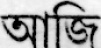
আজি
